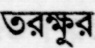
তরক্ষুর
